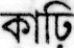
কাঢ়ি
